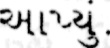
આપ્યું.
